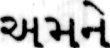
અમને
